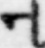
ન
